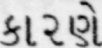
કારણે
